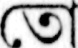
তো
